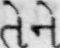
તેને
